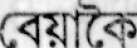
বেয়াকৈ
